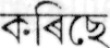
কৰিছে
